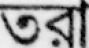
তরা
